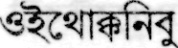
ওইথোক্কনিবু
